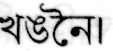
খঙনৈ।
